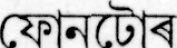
ফোনটোৰ
